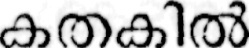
കതകില്‍
